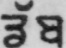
ਡੱਬ
